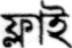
ফ্লাই
